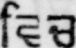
ਵਿਚ
